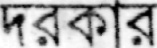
দরকার
